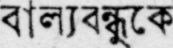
বাল্যবন্ধুকে
